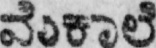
ಮೆಕಾಲೆ
